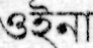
ওইনা
